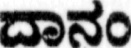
ದಾನಂ
